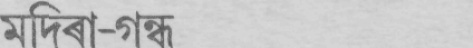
মদিৰা-গন্ধ
